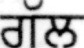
ਗੱਲ
